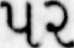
પર
